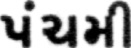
પંચમી
